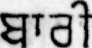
ਬਾਰੀ
